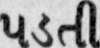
પડતી
